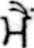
ਮੈਂ
